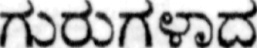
ಗುರುಗಳಾದ
